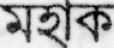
মহাক
